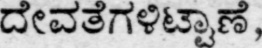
ದೇವತೆಗಳಿಟ್ಟಾಣೆ,
